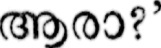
ആരാ?'
